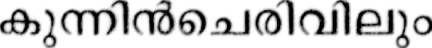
കുന്നിന്‍ചെരിവിലും
